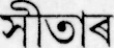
সীতাৰ
